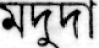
মদুদা
